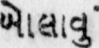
બોલાવું
